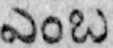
ಎಂಬ
